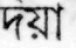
দিয়া
